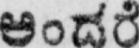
ಅಂದರೆ
